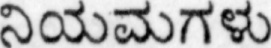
ನಿಯಮಗಳು
